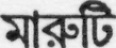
মারুটি
